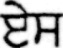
ਏਸ
